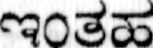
ಇಂತಹ
